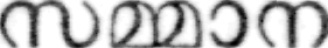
സമ്മാന
